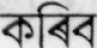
কৰিব
